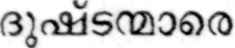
ദുഷ്ടന്മാരെ
